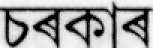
চৰকাৰ
